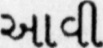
આવી
